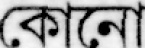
কোনো
